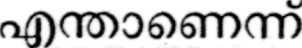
എന്താണെന്ന്
